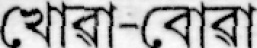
খোৱা-বোৱা
